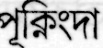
পূক্নিংদা
